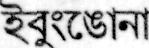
ইবুংঙোনা
